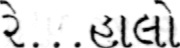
રે...હાલો
